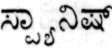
ಸ್ಪ್ಯಾನಿಷ್
